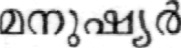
മനുഷ്യര്‍
